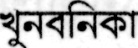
খুনবনিকা
